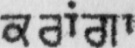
ਕਰਾਂਗਾ
